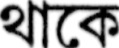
থাকে
